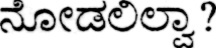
ನೋಡಲಿಲ್ವಾ?
